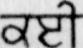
ਕਈ
